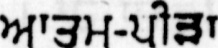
ਆਤਮ-ਪੀੜਾ
